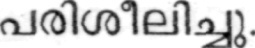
പരിശീലിച്ചു.
